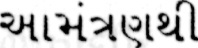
આમંત્રણથી
